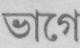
ভাগে
